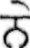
ਨੇ
